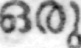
ഒരു
